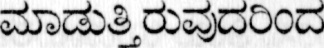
ಮಾಡುತ್ತಿರುವುದರಿಂದ
